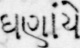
ઘણાંયે
